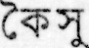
কৈসু
